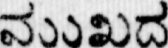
ಮುಖದ
